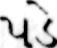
પડે
